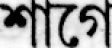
শাগে
